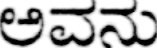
ಅವನು
